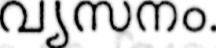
വ്യസനം.
